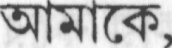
আমাকে,
